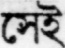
সেই
